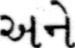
અને
